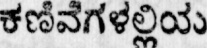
ಕಣಿವೆಗಳಲ್ಲಿಯ
